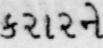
કરારને
